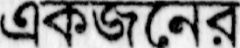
একজনের
